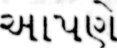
આપણે
